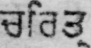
ਚਰਿਤ੍ਰ
